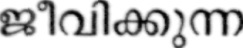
ജീവിക്കുന്ന
